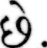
છે.
